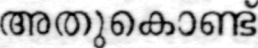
അതുകൊണ്ട്
